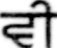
ਵੀ
